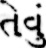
તેવું
